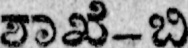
ಶಾಖೆ-ಬಿ
